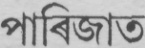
পাৰিজাত
